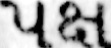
પક્ષ
